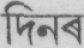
দিনৰ
